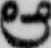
ಆ
